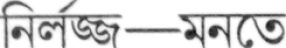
নিৰ্লজ্জ-মনতে
